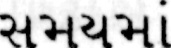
સમયમાં
